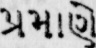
પ્રમાણે
